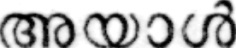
അയാള്‍
